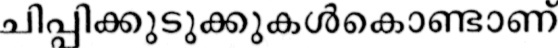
ചിപ്പിക്കുടുക്കുകള്‍കൊണ്ടാണ്
